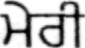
ਮੇਰੀ
